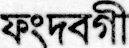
ফংদবগী
